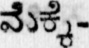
ಮೆಕ್ಕೆ-
